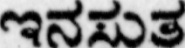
ಇನಸುತ
